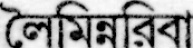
লৈমিন্নরিবা
